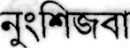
নুংশিজবা
